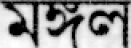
মঙ্গল
